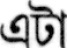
এটা
